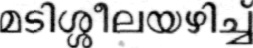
മടിശ്ശീലയഴിച്ച്
